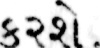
કરશે.
